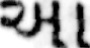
આ
